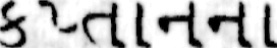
કપ્તાનના
